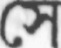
সে
